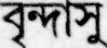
বৃন্দাসু
